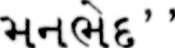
મનભેદ"
